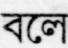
বলে
